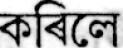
কৰিলে
